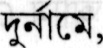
দুর্নামে,
